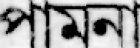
পামনা
